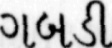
ગબડી
